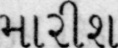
મારીશ
